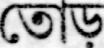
তোড়
